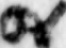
જ
